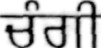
ਚੰਗੀ
